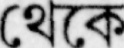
থেকে
